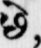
છે,
